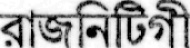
রাজনিটিগী
